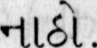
નાઠો.
